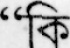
"কি
